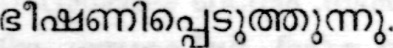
ഭീഷണിപ്പെടുത്തുന്നു.
